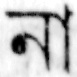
না
